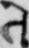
તે
